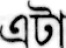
এটা
